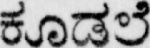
ಕೂಡಲೆ
